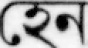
হেন
